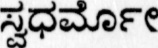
ಸ್ವಧರ್ಮೋ
